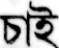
চাই
